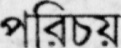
পরিচয়
